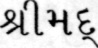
શ્રીમદ્
